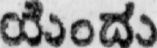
ಯೆ೦ದು
